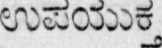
ಉಪಯುಕ್ತ
